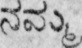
ನಮ್ಮ
